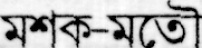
মশক-মতৌ
